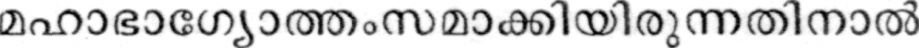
മഹാഭാഗ്യോത്തംസമാക്കിയിരുന്നതിനാല്‍
